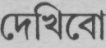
দেখিবো
